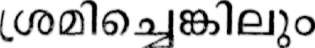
ശ്രമിച്ചെങ്കിലും
